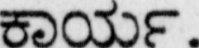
ಕಾರ್ಯ.
